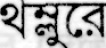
থম্লুরে
